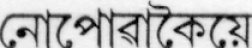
নোপোৱাকৈয়ে
